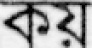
কয়
